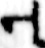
ન
